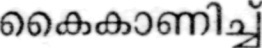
കൈകാണിച്ച്
